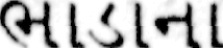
ભાડાના
